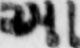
આ
